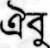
ঐবু
